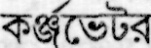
কর্ঞ্জভেটর
